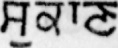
ਸੁਕਾਣ
